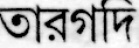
তারগদি
